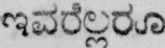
ಇವರೆಲ್ಲರೂ
